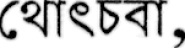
থোৎচবা,
